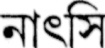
নাৎসি
